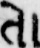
તો
